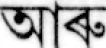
আৰু
